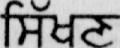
ਸਿੱਖਣ
